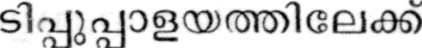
ടിപ്പുപ്പാളയത്തിലേക്ക്
